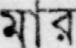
মার
